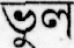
ভুল
